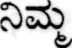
ನಿಮ್ಮ
